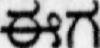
ಈಗ
